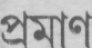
প্ৰমাণ
